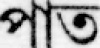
পাত
